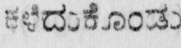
ಕಳೆದುಕೊಂಡು
